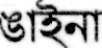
ঙাইনা
